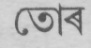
তোৰ
